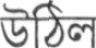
উঠিল
